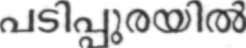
പടിപ്പുരയില്‍
